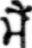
ਮੈਂ
